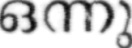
ഒന്നു
